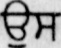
ਉਸ
